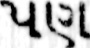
પણ
